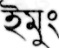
ইমুং
